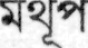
মথূপ
